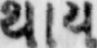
થાય
